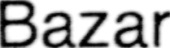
Bazar
